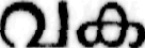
വക
